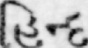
હિન્દ
